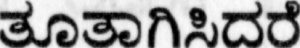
ತೂತಾಗಿಸಿದರೆ
